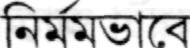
নির্মমভাবে
